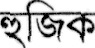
হুজিক
